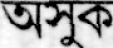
অসুক
